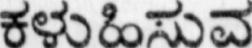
ಕಳುಹಿಸುವ
